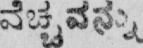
ವೆಚ್ಚವನ್ನು
